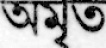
অমৃত
